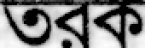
তরক
